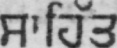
ਸਾਹਿੱਤ
